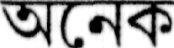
অনেক
